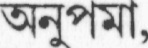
অনুপমা,
